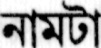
নামটা
